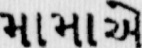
મામાએ
